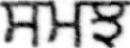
ਸਮਝ
